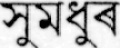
সুমধুৰ
